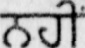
ਨਹੀਂ
